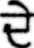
ਦੇ
